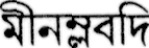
মীনম্লবদি
